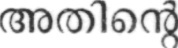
അതിന്റെ
